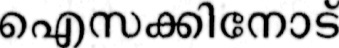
ഐസക്കിനോട്
